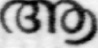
ആ
